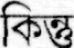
কিন্তু
